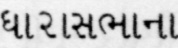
ધારાસભાના
